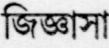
জিজ্ঞাসা
